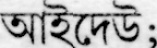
আইদেউ;
